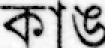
কাঙ
